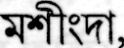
মশীংদা,
